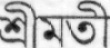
শ্ৰীমতী
